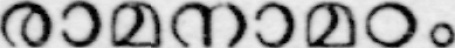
രാമനാമഠം
